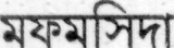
মফমসিদা
